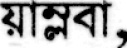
য়াম্লবা,
